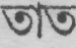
তাত
